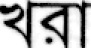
খরা
